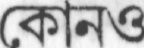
কোনও
